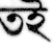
তই
